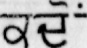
ਕਦੋਂ
